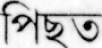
পিছত
